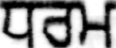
ਧਰਮ
